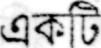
একটি
